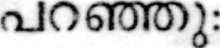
പറഞ്ഞു:
